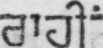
ਰਾਹੀਂ
